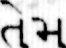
તેમ
